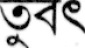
তুবৎ
